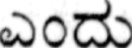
ಎಂದು
